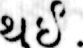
થઈ.
